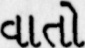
વાતો
